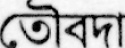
তৌবদা
